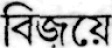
বিজয়ে
